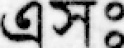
এসঃ
